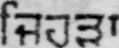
ਜਿਹੜਾ
